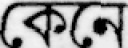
কেনে
